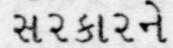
સરકારને
